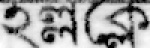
হল্লক্লে
